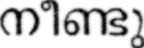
നീണ്ടു
